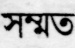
সম্মত
